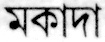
মকাদা
